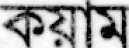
কয়াম
